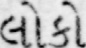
લોકો
